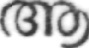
ആ
